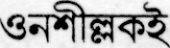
ওনশীল্লকই
